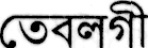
তেবলগী
